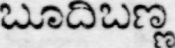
ಬೂದಿಬಣ್ಣ
